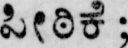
ಪೀಠಿಕೆ;
